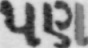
પણ
